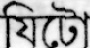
যিটো
